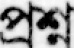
প্রশ্ন
